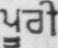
ਪੂਰੀ
